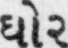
ઘોર
